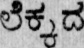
ಲೆಕ್ಕದ
